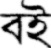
বই
